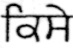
ਕਿਸੇ
